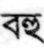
বহু
